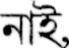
নাই,
